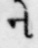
ને
